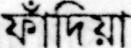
ফাঁদিয়া
